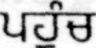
ਪਹੁੰਚ
